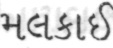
મલકાઈ
